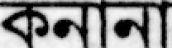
কনানা
